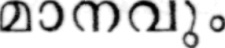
മാനവും,
